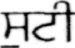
ਸੁਟੀ
